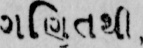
ગણિતથી,
